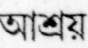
আশ্রয়
